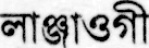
লাঞ্জাওগী
